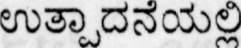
ಉತ್ಪಾದನೆಯಲ್ಲಿ
